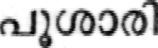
പൂശാരി
